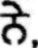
ਨੇ,
